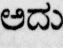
ಅದು
